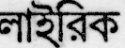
লাইরিক
